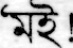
'মই!
